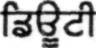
ਡਿਊਟੀ
